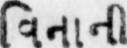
વિનાની
